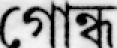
গোন্ধ
